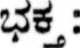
ಭಕ್ತ:
